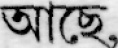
আছে,
